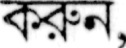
করুন,
